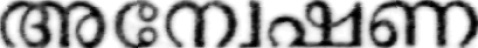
അന്വേഷണ
